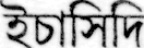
ইচাসিদি
